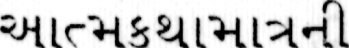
આત્મકથામાત્રની
